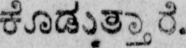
ಕೊಡುತ್ತಾರೆ.
